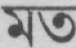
মত
